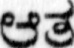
ಆತ
